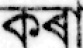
কৰা
